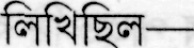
লিখিছিল-
